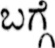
ಬಗ್ಗೆ
